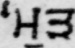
'ਮੁੜ
